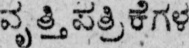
ವೃತ್ತಿಪತ್ರಿಕೆಗಳ
